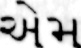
એમ
